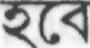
হবে
